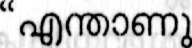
"എന്താണു
